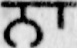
ਨਾ
